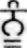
ਨੂੰ
